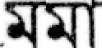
মমা
